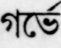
গর্ভে
